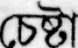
চেষ্টা
